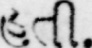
હતી.
